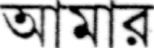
আমার
